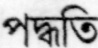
পদ্ধতি
